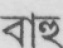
বাহু
